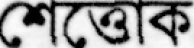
শেত্তোক
